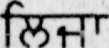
ਲਿਜਾ
